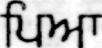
ਪਿਆ
